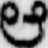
ಆ
